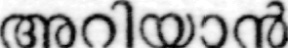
അറിയാന്‍
